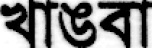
খাঙবা
